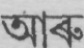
আৰু
